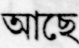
আছে
